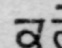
ਕਰੇ
